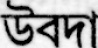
উবদা
